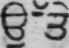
ਉੱਤੇ
